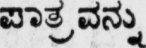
ಪಾತ್ರವನ್ನು
